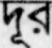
দূর
